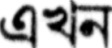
এখন
